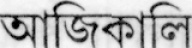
আজিকালি
